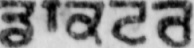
ਡਾਕਟਰ
